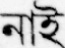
নাই
